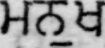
ਮਨੁਖ
